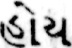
હોય
